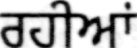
ਰਹੀਆਂ
